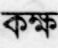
কক্ষ
